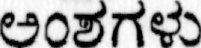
ಅಂಶಗಳು
